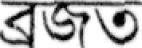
ব্রজত
